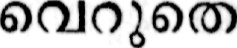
വെറുതെ
